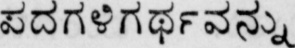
ಪದಗಳಿಗರ್ಥವನ್ನು
